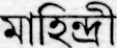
মাহিন্দ্রী
